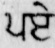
ਪਏ
